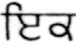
ਇਕ
